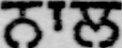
ਨਾਲ
